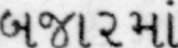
બજારમાં
